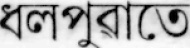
ধলপুৱাতে
